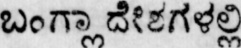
ಬಂಗ್ಲಾದೇಶಗಳಲ್ಲಿ
